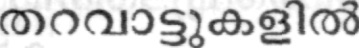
തറവാട്ടുകളില്‍
